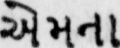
એમના
